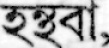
হন্থবা,
